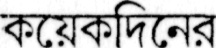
কয়েকদিনের
